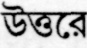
উত্তরে
